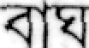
বাঘ
